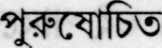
পুরুষোচিত
